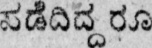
ಪಡಿದಿದ್ದರೂ
